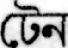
টেন
